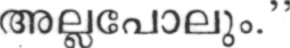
അല്ലപോലും."
